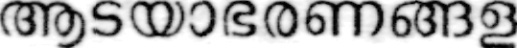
ആടയാഭരണങ്ങള
